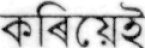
কৰিয়েই
